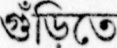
গুঁড়িতে
